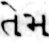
તેમ
